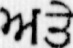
ਅਤੇ
